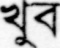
খুব
